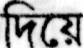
দিয়ে
